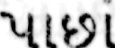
પાછાં
